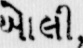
બોલી,
